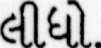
લીધો.
